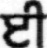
ਈ
